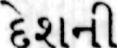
દેશની
